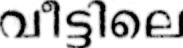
വീട്ടിലെ
